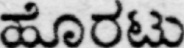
ಹೊರಟು
